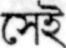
সেই
